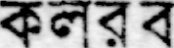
কলরব
